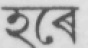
হৰে
